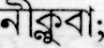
নীক্লুবা;
